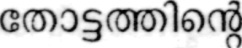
തോട്ടത്തിന്റെ
